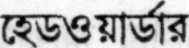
হেডওয়ার্ডার
